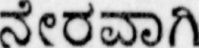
ನೇರವಾಗಿ
